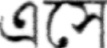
এসে
